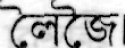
লৈজৈ।
